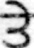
ਤੇ
